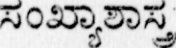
ಸಂಖ್ಯಾಶಾಸ್ತ್ರ
